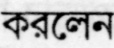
করলেন
